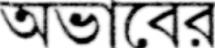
অভাবের
